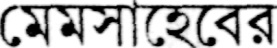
মেমসাহেবের
